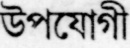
উপযোগী
